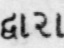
દ્વારા
